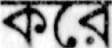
করে
